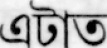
এটাত
